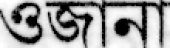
ওজানা
